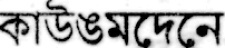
কাউঙমদেনে
